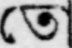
তো
